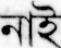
নাই
